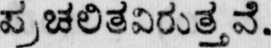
ಪ್ರಚಲಿತವಿರುತ್ತವೆ.
